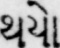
થયો
